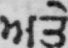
ਅਤੇ
